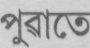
পুৱাতে
